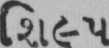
શિલ્પ
